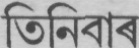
তিনিবাৰ
